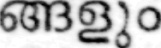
ങ്ങളും
